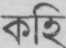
কহি
